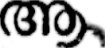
ആ
